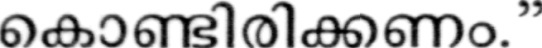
കൊണ്ടിരിക്കണം."
